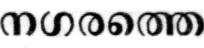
നഗരത്തെ
